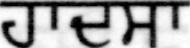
ਹਾਦਸਾ
